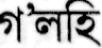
গ'লহি
